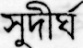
সুদীর্ঘ
